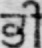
ਭੀ
